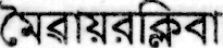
মৈৱায়রক্লিবা
